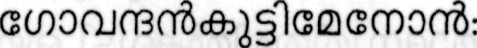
ഗോവന്ദന്‍കുട്ടിമേനോന്‍:
